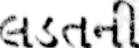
લડતની
